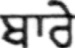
ਬਾਰੇ
